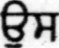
ਉਸ
